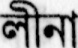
লীনা
